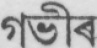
গভীৰ
